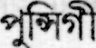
পুন্সিগী
